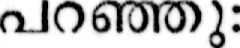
പറഞ്ഞു:
